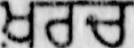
ਖ਼ਰਚ
